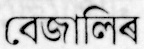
বেজালিৰ
